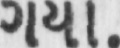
ગયા.
